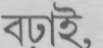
বঢ়াই,
